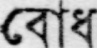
বোধ
